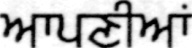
ਆਪਣੀਆਂ
